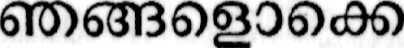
ഞങ്ങളൊക്കെ
